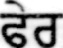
ਫੇਰ
